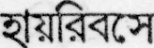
হায়রিবসে
